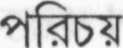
পরিচয়
